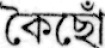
কৈছোঁ
